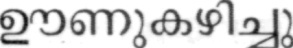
ഊണുകഴിച്ചു
